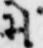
મેં
